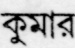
কুমার
